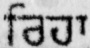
ਰਿਹਾ
